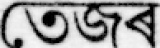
তেজৰ
